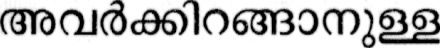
അവര്‍ക്കിറങ്ങാനുള്ള
